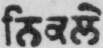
ਨਿਕਲੇ
